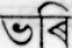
ভৰি
